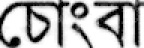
চোংবা
